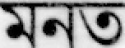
মনত
